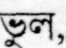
ভুল,
